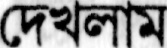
দেখলাম
